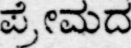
ಪ್ರೇಮದ
